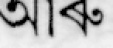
আৰু
